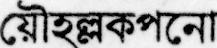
য়ৌহল্লকপনো
